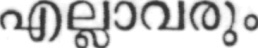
എല്ലാവരും
